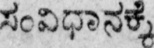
ಸಂವಿಧಾನಕ್ಕೆ
